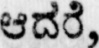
ಆದರೆ,
